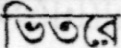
ভিতরে
